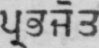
ਪ੍ਰਭਜੋਤ
